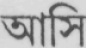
আসি
